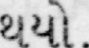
થયો.
